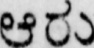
ಆರು
